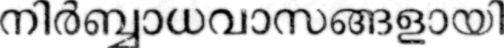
നിര്‍ബ്ബാധവാസങ്ങളായി
